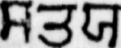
ਸਤਯ
